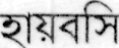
হায়বসি
